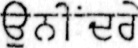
ਉਨੀਂਦਰੇ
